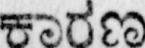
ಕಾರಣ
